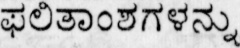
ಫಲಿತಾಂಶಗಳನ್ನು
